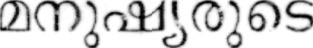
മനുഷ്യരുടെ
